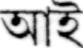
আই
